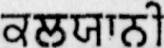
ਕਲਯਾਨੀ
